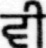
ਵੀ
